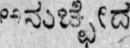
ಅನುಚ್ಛೇದ
